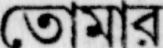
তোমার
